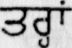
ਤਰ੍ਹਾਂ
